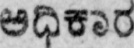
ಅಧಿಕಾರ
